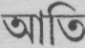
আতি
